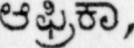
ಆಫ್ರಿಕಾ,
